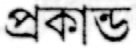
প্রকান্ড
